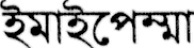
ইমাইপেম্মা
